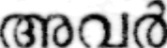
അവര്‍
